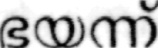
ഭയന്ന്
